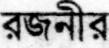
রজনীর
